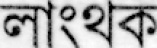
লাংথক
